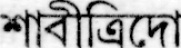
শাবীত্রিদো
